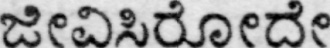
ಜೀವಿಸಿರೋದೇ
